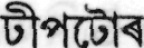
ঢীপটোৰ
